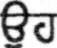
ਉਹ
